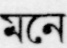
মনে
